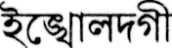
ইঙ্খোলদগী
